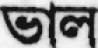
ভাল
